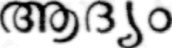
ആദ്യം
